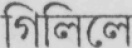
গিলিলে
